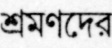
শ্রমণদের
